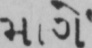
માર્ગે
